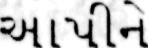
આપીને
